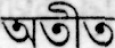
অতীত
